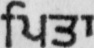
ਪਿਤਾ
